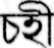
চহী
